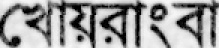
খোয়রাংবা
